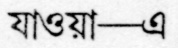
যাওয়া–এ
